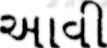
આવી
